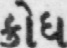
ક્રોધ
